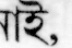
নাই,
